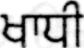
ਖਾਧੀ
